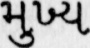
મુખ્ય
